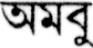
অমবু
